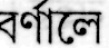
বর্ণালে
